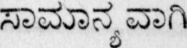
ಸಾಮಾನ್ಯವಾಗಿ
